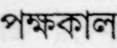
পক্ষকাল
